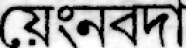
য়েংনবদা
